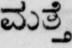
ಮತ್ತೆ
